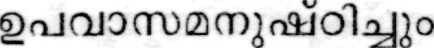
ഉപവാസമനുഷ്ഠിച്ചും
